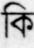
কি
